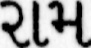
રામ
